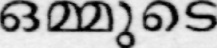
ഒമ്മുടെ
